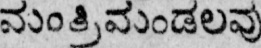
ಮಂತ್ರಿಮಂಡಲವು
